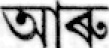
আৰু
